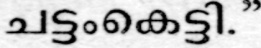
ചട്ടംകെട്ടി."
